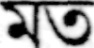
মত
